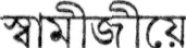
স্বামীজীয়ে
